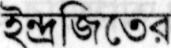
ইন্দ্রজিতের
